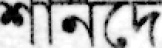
শানদে
